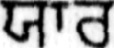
ਯਾਰ
